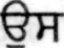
ਉਸ
